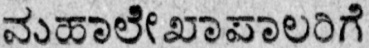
ಮಹಾಲೇಖಾಪಾಲರಿಗೆ
